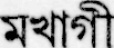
মখাগী
